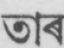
তাৰ
